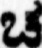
ಚ
